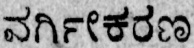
ವರ್ಗೀಕರಣ
